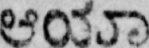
ಆಯಾ
